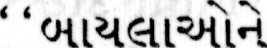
"બાયલાઓને
